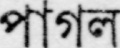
পাগল
